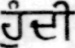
ਹੁੰਦੀ
